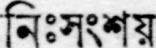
নিঃসংশয়
